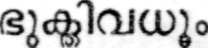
ഭുക്തിവധൂം
